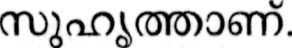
സുഹൃത്താണ്.
